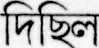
দিছিল
